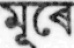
মূৰে
